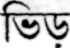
ভিড়
